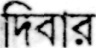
দিবার
